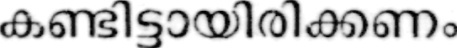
കണ്ടിട്ടായിരിക്കണം
